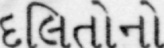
દલિતોનો
